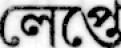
লেপ্তে
